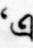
‘এ
